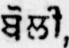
ਬੋਲੀ,
